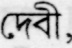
দেবী,
